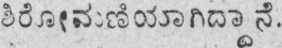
ಶಿರೋಮಣಿಯಾಗಿದ್ದಾನೆ.
